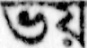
ভয়
